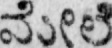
ಮೇಲೆ
